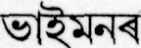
ভাইমনৰ
